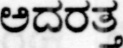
ಅದರತ್ತ
